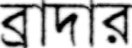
ব্রাদার
